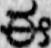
ಈ
